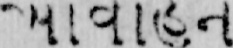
આવાહન
